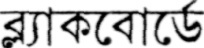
ব্ল্যাকবোর্ডে
